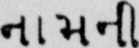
નામની
